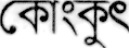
কোংকুৎ
